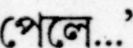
পেলে...’
